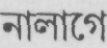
নালাগে
